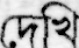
দেখি
